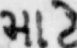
માટે
